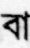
বা
